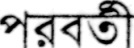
পরবর্তী
